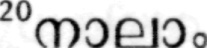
20നാലാം
